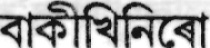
বাকীখিনিৰো
